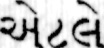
એટલે
